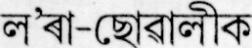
ল'ৰা-ছোৱালীক
